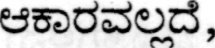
ಆಕಾರವಲ್ಲದೆ,
